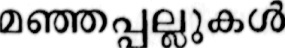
മഞ്ഞപ്പല്ലുകള്‍
